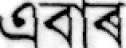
এবাৰ
